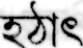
হঠাৎ
